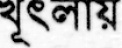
খূৎলায়
